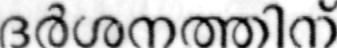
ദര്‍ശനത്തിന്
